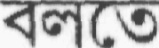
বলতে
